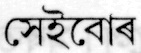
সেইবোৰ
